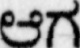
ಆಗ
